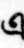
এ
